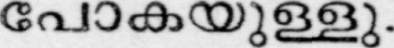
പോകയുള്ളു.
